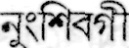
নুংশিবগী
